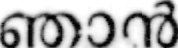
ഞാന്‍
